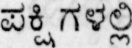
ಪಕ್ಷಿಗಳಲ್ಲಿ
